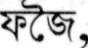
ফজৈ,
